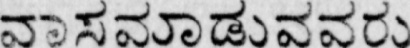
ವಾಸಮಾಡುವವರು
